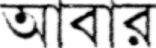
আবার
